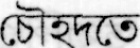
চৌহদতে
